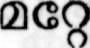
മറ്റേ
